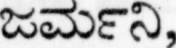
ಜರ್ಮನಿ,
